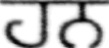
ਹਨ
